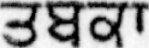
ਤਬਕਾ
